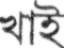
খাই
